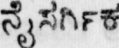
ನೈಸರ್ಗಿಕ
